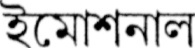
ইমোশনাল
